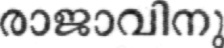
രാജാവിനു
